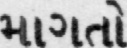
માગતો
